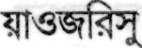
য়াওজরিসু
